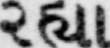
રહ્યા
